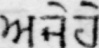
ਅਜੇਹੇ
